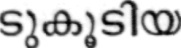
ടുകൂടിയ
